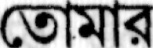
তোমার
